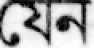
যেন
